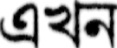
এখন
